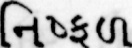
નિષ્ફળ
